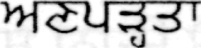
ਅਣਪੜ੍ਹਤਾ
